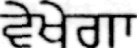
ਵੇਖੇਗਾ
